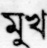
মুখ
